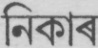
নিকাৰ
